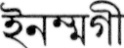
ইনম্মগী
